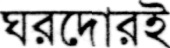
ঘরদোরই
